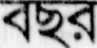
বছর
